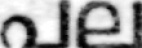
പല
